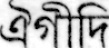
ঐগীদি
